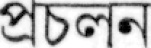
প্রচলন
